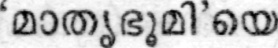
'മാതൃഭൂമി'യെ
